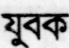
যুবক
